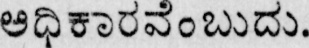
ಅಧಿಕಾರವೆಂಬುದು.
